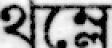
থম্লে
